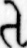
તે
